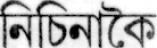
নিচিনাকৈ
